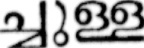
ച്ചുള്ള
